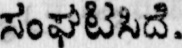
ಸಂಘಟಿಸಿದೆ.
